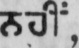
ਨਹੀਂ,
